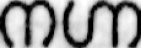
നഗ്ന
